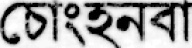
চোংহনবা
